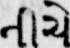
નીચે
